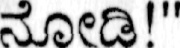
ನೋಡಿ!”
